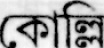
কোল্লি
